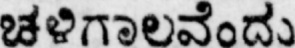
ಚಳಿಗಾಲವೆಂದು
